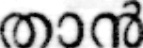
താന്‍
